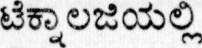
ಟೆಕ್ನಾಲಜಿಯಲ್ಲಿ
